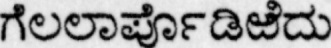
ಗೆಲಲಾರ್ಪೊಡಿಱದು
